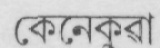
কেনেকুৱা
